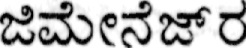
ಜಿಮೇನೆದ್ರ
